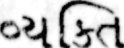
વ્યક્તિ
